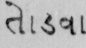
તોડવા
